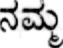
ನಮ್ಮ
